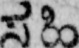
ಸಹಿ
